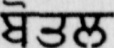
ਬੋਤਲ
